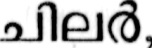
ചിലര്‍,
